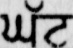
ਘੱਟ
